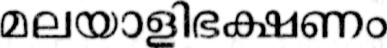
മലയാളിഭക്ഷണം
